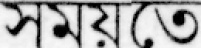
সময়তে
